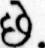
છે.
